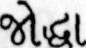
જોદ્ધા
